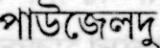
পাউজেলদু
